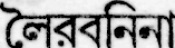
লৈরবনিনা
